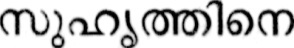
സുഹൃത്തിനെ
